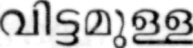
വിട്ടമുള്ള
